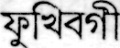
ফুখিবগী
